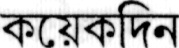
কয়েকদিন
